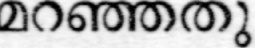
മറഞ്ഞതു
